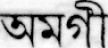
অমগী
